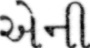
એની
